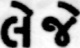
લેજે
